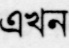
এখন
